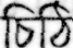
চিঠি
